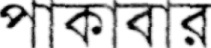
পাকাবার
